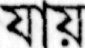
যায়
